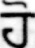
ਹੋ
